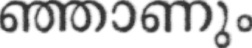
ഞ്ഞാണും
